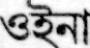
ওইনা
